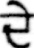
ਦੇ
